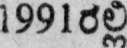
1991ರಲ್ಲಿ
